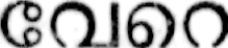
വേറെ
